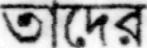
তাদের
